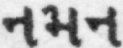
નમન
